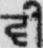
ਵੀ
